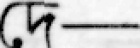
দে-
